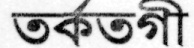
তর্কতগী
